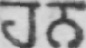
ਹਨ
